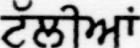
ਟੱਲੀਆਂ
